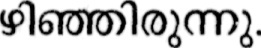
ഴിഞ്ഞിരുന്നു.
